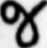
જ
